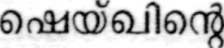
ഷെയ്ഖിന്റെ
